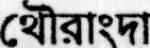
থৌরাংদা
